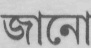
জানো
